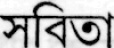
সবিতা
